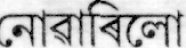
নোৱাৰিলো
